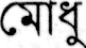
মোধু
